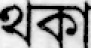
থকা
